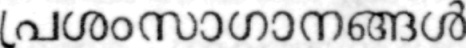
പ്രശംസാഗാനങ്ങള്‍
